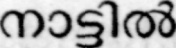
നാട്ടില്‍
